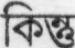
কিন্তু
